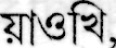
য়াওখি,
